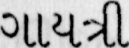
ગાયત્રી
